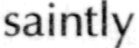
saintly
